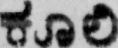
ಕೂಲಿ
